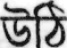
উঠি
